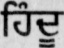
ਹਿੰਦੂ
